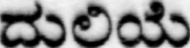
ದುಲಿಯೆ
